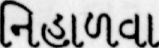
નિહાળવા
